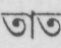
তাত
